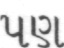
પણ
